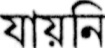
যায়নি
